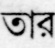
তার
